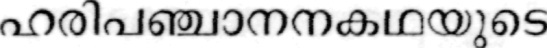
ഹരിപഞ്ചാനനകഥയുടെ
